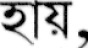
হায়,
